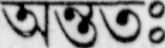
অন্ততঃ
